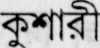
কুশারী
